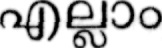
എല്ലാം
